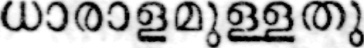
ധാരാളമുള്ളതു
